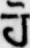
ਹੋ
